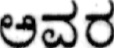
ಅವರ
